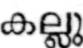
കല്ലു
